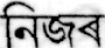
নিজৰ
